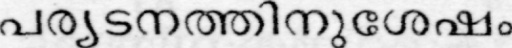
പര്യടനത്തിനുശേഷം
